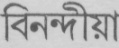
বিনন্দীয়া
